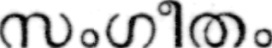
സംഗീതം
